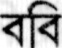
ববি
